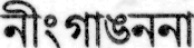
নীংগাঙননা
